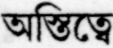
অস্তিত্বে
